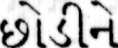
છોડીને
